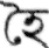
হৈ
